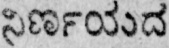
ನಿರ್ಣಯದ
